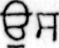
ਉਸ
